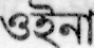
ওইনা
